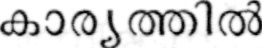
കാര്യത്തില്‍
